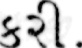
કરી.
